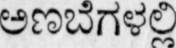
ಅಣಬೆಗಳಲ್ಲಿ
